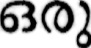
ഒരു
